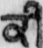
ਕੀ
